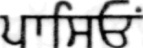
ਪਾਸਿਓਂ
